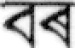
বৰ
